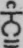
ਨੂੰ
